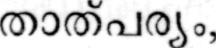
താത്പര്യം,
